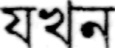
যখন
